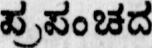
ಪ್ರಪಂಚದ
